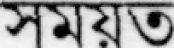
সময়ত
